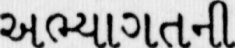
અભ્યાગતની
